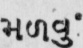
મળવું
